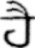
ਹੈ
